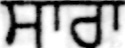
ਸਾਰਾ
